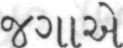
જગાએ
